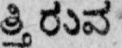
ತ್ತಿರುವ
